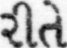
રીતે
